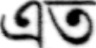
এত
